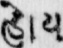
હોય
